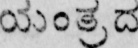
ಯಂತ್ರದ
